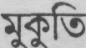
মুকুতি
